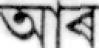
আৰ
